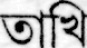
তাখি
